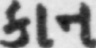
કાન
